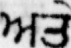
ਅਤੇ
